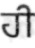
ਹੀ
